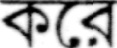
করে
